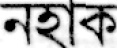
নহাক
